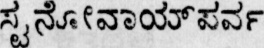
ಸ್ಟನೋವಾಯ್‌ಪರ್ವ
